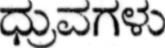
ಧ್ರುವಗಳು
